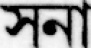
সনা
